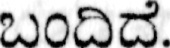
ಬಂದಿದೆ.
